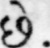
છે.
